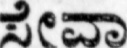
ಸೇವಾ
